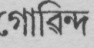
গোৱিন্দ
